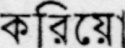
করিয়ো
